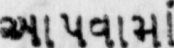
આપવામાં
